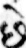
છે
